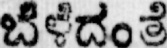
ಬೆಳೆದಂತೆ
